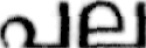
പല
